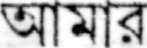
আমার
